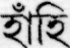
হাঁহি
